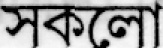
সকলো
